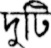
দুটি
